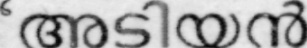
'അടിയന്‍
